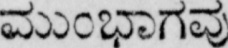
ಮುಂಭಾಗವು
